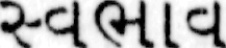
સ્વભાવ
